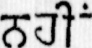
ਨਹੀਂ
